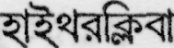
হাইথরক্লিবা
